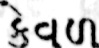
કેવળ
